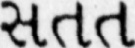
સતત
